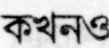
কখনও
